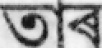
তাৰ
